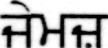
ਜੇਮਜ਼
